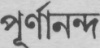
পূৰ্ণানন্দ
